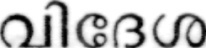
വിദേശ
